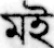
মই
